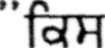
''ਕਿਸ
